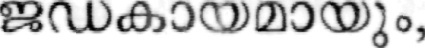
ജഡകായമായും,
